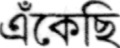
এঁকেছি
